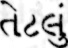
તેટલું
